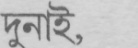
দুনাই,
